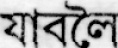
যাবলৈ
